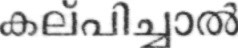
കല്പിച്ചാല്‍
